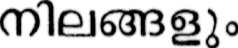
നിലങ്ങളും
